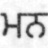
ਮਨ
